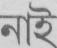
নাই
